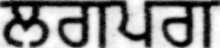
ਲਗਪਗ
